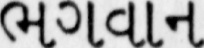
ભગવાન
